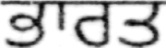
ਭਾਰਤ
